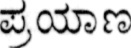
ಪ್ರಯಾಣ
